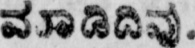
ಮಾಡಿದಿವು.
